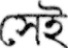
সেই
